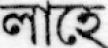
লাহে
